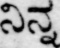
ನಿನ್ನ
